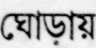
ঘোড়ায়
